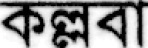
কল্লবা
